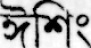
ঈশিং
